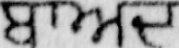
ਬਾਅਦ
